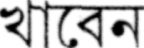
খাবেন
